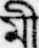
মী
